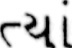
ત્યાં
